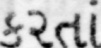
કરતાં
